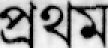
প্রথম
